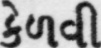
કેળવી
